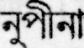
নুপীনা
